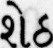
શેઠ
